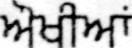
ਔਖੀਆਂ
